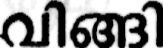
വിങ്ങി
